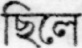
ছিলে
